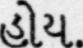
હોય.
